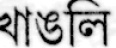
খাঙলি
